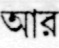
আর
